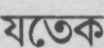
যতেক
